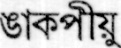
ঙাকপীয়ু
